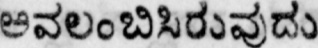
ಅವಲಂಬಿಸಿರುವುದು
